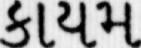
કાયમ
